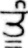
ਤੂੰ
